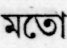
মতো
